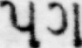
પગ
